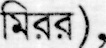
মিরর),
